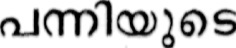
പന്നിയുടെ
